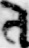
તે
